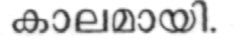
കാലമായി.
